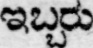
ಇಬ್ಬರು
